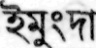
ইমুংদা
